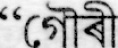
"গৌৰী
